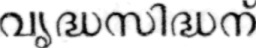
വൃദ്ധസിദ്ധന്
